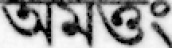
অমত্তং
